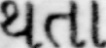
થતા
